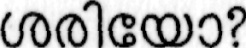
ശരിയോ?
